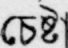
চেষ্টা
